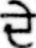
ਦੇ
